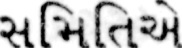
સમિતિએ
